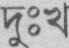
দুঃখ
